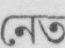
নেত
